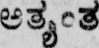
ಅತ್ಯಂತ
